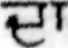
ਦਾ
